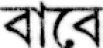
বাবে
